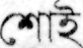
শোই
